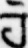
ਹੋ
